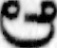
ಆ
